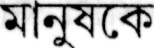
মানুষকে
